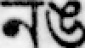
নঙ
